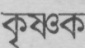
কৃষ্ণক
